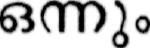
ഒന്നും
